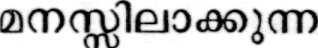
മനസ്സിലാക്കുന്ന
